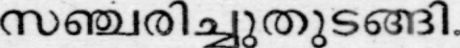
സഞ്ചരിച്ചുതുടങ്ങി.
